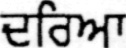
ਦਰਿਆ
